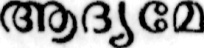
ആദ്യമേ
